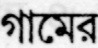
গামের
